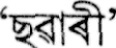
'ছৱাৰী'
